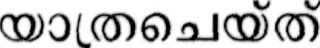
യാത്രചെയ്ത്
